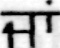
ਜਾਂ
